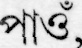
পাওঁ,
